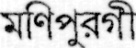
মণিপুরগী
